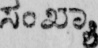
ಸಂಖ್ಯಾ
